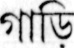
গাড়ি
